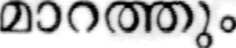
മാറത്തും
